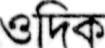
ওদিক
